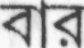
বার
